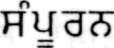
ਸੰਪੂਰਨ
